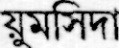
য়ুমসিদা
